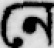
নে
